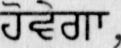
ਹੋਵੇਗਾ,
